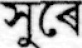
সুৰে
